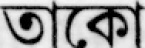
তাকো
